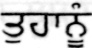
ਤੁਹਾਨੂੰ
